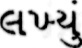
લખ્યું
